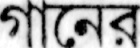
গানের
